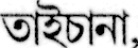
তাইচানা,
